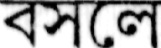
বসলে
